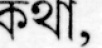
কথা,
